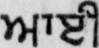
ਆਈ
